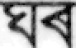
ঘৰ
